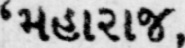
'મહારાજ,
